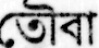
তৌবা
